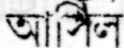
আসিল
